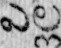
ಎಲ್ಲ
